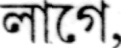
লাগে,
